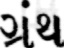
ગ્રંથ
